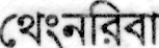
থেংনরিবা
